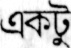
একটু
